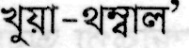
‘খুয়া-থম্বাল’
